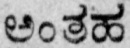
ಅಂತಹ
